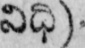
ನಿಧಿ).
